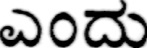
ಎಂದು
